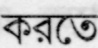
করতে
